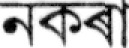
নকৰা
